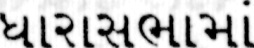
ધારાસભામાં
